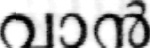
വാന്‍
